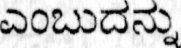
ಎಂಬುದನ್ನು
